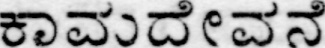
ಕಾಮದೇವನೆ
